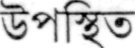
উপস্থিত
